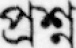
প্রশ্ন
